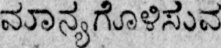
ಮಾನ್ಯಗೊಳಿಸುವ
